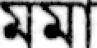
মমা
